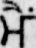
ਮੈਂ
